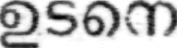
ഉടനെ
